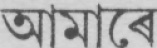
আমাৰে
